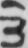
ਤੇ
